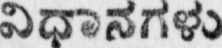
ವಿಧಾನಗಳು
